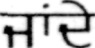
ਜਾਂਦੇ
